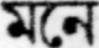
মনে
